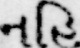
નહિ
